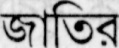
জাতির
